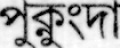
পুক্নুংদা
